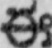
ಈ
